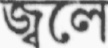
জ্বলে
